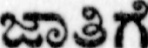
ಜಾತಿಗೆ
